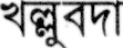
খল্লুবদা
